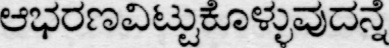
ಆಭರಣವಿಟ್ಟುಕೊಳ್ಳುವುದನ್ನೆ
